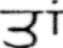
ਤਾਂ
